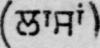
(ਲਾਸਾਂ)
